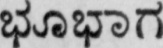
ಭೂಭಾಗ
